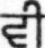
ਵੀ
